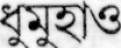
ধুমুহাও
